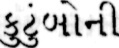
કુટુંબોની
